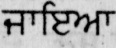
ਜਾਇਆ
